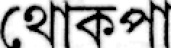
থোকপা
